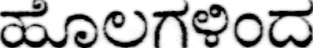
ಹೊಲಗಳಿಂದ
